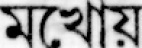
মখোয়
